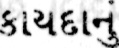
કાયદાનું
